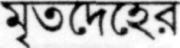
মৃতদেহের
